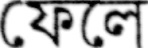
ফেলে
